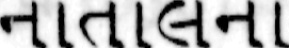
નાતાલના
